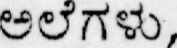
ಅಲೆಗಳು,
